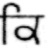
ਕਿ
